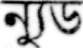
ন্যুড
